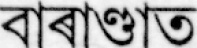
বাৰাণ্ডাত
